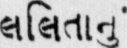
લલિતાનું
